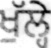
ਖੁੱਲ੍ਹੇ
